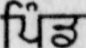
ਪਿੰਡ
